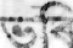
ভৰি
